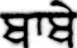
ਬਾਬੇ
